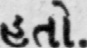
હતો.
